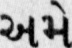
અમે
